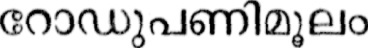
റോഡുപണിമൂലം
